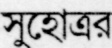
সুহোত্রর
